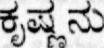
ಕೃಷ್ಣನು
